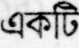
একটি
